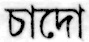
চাদো
